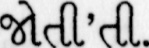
જોતી'તી.
